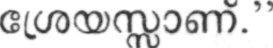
ശ്രേയസ്സാണ്."
